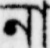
না
